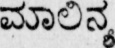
ಮಾಲಿನ್ಯ
